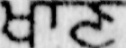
ਖਾਣ
